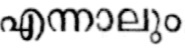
എന്നാലും
